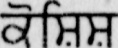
ਕੋਸ਼ਿਸ਼
